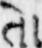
તો
